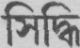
সিদ্ধি
